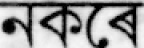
নকৰে
